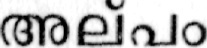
അല്പം
